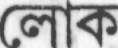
লোক
